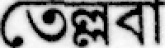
তেল্লবা
